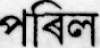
পৰিল
